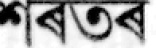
শৰতৰ
